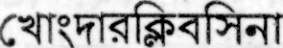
খোংদারক্লিবসিনা
